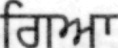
ਗਿਆ
